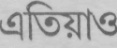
এতিয়াও
